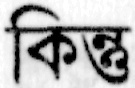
কিন্তু
